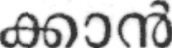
ക്കാന്‍
